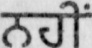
ਨਹੀਂ
